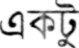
একটু
